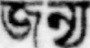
জন্য
